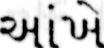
આંખે
